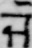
ਜੋ
